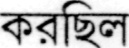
করছিল
